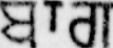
ਬਾਗ
